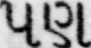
પણ
